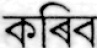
কৰিব
